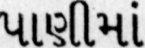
પાણીમાં
